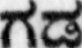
ಗಡ
